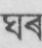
ঘৰ
